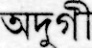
অদুগী
